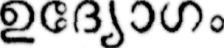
ഉദ്യോഗം
